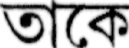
তাকে
